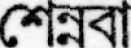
শেন্নবা
